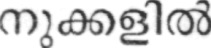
നുക്കളില്‍
